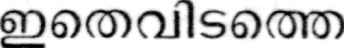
ഇതെവിടത്തെ
